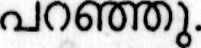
പറഞ്ഞു.
